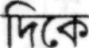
দিকে
